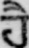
ਹੈ
